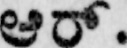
ಆರ್.
